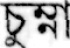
চুম্না
